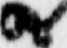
જ
